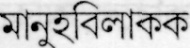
মানুহবিলাকক
